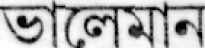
ভালেমান
